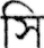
সি
